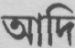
আদি
